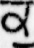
ਕੁ
